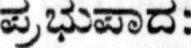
ಪ್ರಭುಪಾದ:
